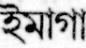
ইমাগা
